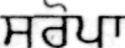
ਸਰੋਪਾ
